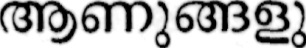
ആണുങ്ങളു
